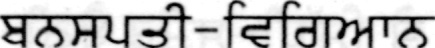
ਬਨਸਪਤੀ-ਵਿਗਿਆਨ
